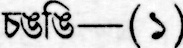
চঙঙি-(১)
